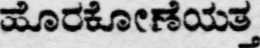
ಹೊರಕೋಣೆಯತ್ತ
